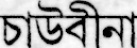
চাউবীনা
